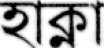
হাক্না
